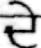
ਦੇ
